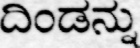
ದಿಂಡನ್ನು
